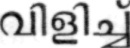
വിളിച്ച്
